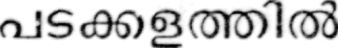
പടക്കളത്തില്‍
